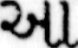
આ
